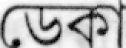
ডেকা
